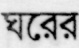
ঘরের
